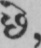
છે.
